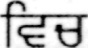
ਵਿਚ
